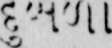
દુબળા
